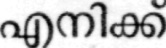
എനിക്ക്
